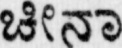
ಚೀನಾ
